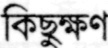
কিছুক্ষণ
